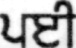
ਪਈ
